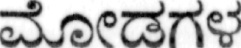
ಮೋಡಗಳ
